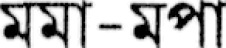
মমা-মপা
